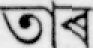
তাৰ
